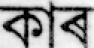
কাৰ
